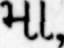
મા,
